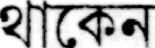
থাকেন
